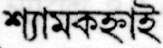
শ্যামকহ্ণাই
